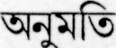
অনুমতি
